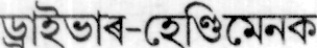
ড্ৰাইভাৰ-হেণ্ডিমেনক
